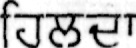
ਹਿਲਦਾ
